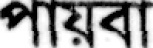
পায়বা
